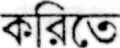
করিতে
